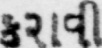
કરાવી
